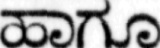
ಹಾಗೂ
